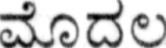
ಮೊದಲ
